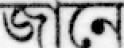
জানে
